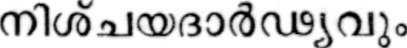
നിശ്ചയദാര്‍ഢ്യവും
